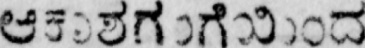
ಆಕಾಶಗಂಗೆಯಿಂದ
